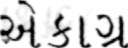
એકાગ્ર
